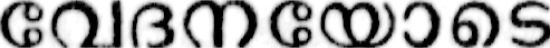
വേദനയോടെ
